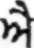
ਐ
